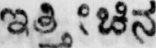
ಇತ್ತೀಚಿನ
